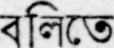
বলিতে
